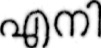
എനി
